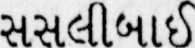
સસલીબાઈ
